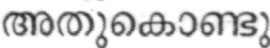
അതുകൊണ്ടു
